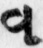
વ
